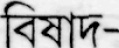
বিষাদ-
